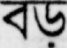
বড়
